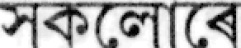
সকলোৰে
